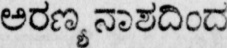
ಅರಣ್ಯನಾಶದಿಂದ
